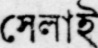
সেলাই
